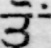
ਤੋਂ
